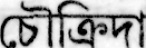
চৌক্রিদা
